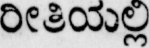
ರೀತಿಯಲ್ಲಿ
